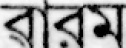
ৱারম
